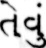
તેવું
